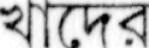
খাদের
